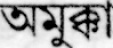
অমুক্কা
